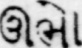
ઊભો
